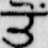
ਤੋਂ
